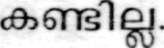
കണ്ടില്ല.
